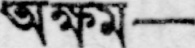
অক্ষম—
